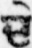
ਦੇ
